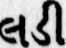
લડી
